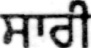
ਸਾਰੀ
